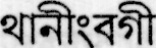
থানীংবগী
